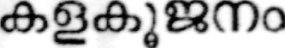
കളകൂജനം
